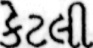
કેટલી
